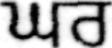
ਘਰ
